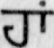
ਹਾਂ
